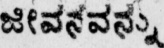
ಜೀವನವನ್ನು
